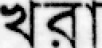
খরা
